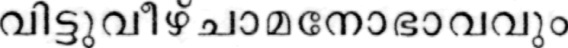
വിട്ടുവീഴ്ചാമനോഭാവവും
